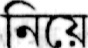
নিয়ে
